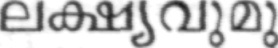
ലക്ഷ്യവുമു
